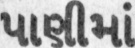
પાણીમાં
